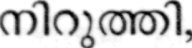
നിറുത്തി,
